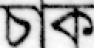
চাক
